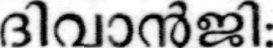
ദിവാന്‍ജി:
